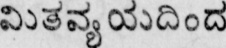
ಮಿತವ್ಯಯದಿಂದ
